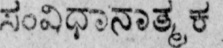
ಸಂವಿಧಾನಾತ್ಮಕ
